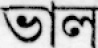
ভাল
